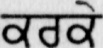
ਕਰਕੇ
